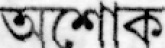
অশোক
